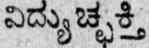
ವಿದ್ಯುಚ್ಛಕ್ತಿ
